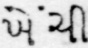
ખેંચી
